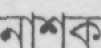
নাশক
